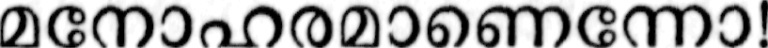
മനോഹരമാണെന്നോ!
